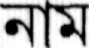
নাম
